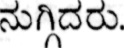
ನುಗ್ಗಿದರು.
